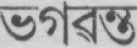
ভগৱন্ত
